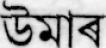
উমাৰ
